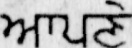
ਆਪਣੇ
